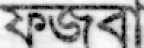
ফজবা
